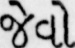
જેવો
